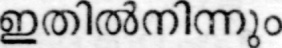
ഇതില്‍നിന്നും
